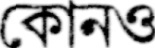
কোনও
